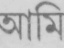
আমি
